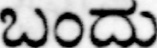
ಬಂದು
